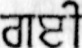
ਗਈ
